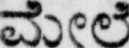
ಮೇಲೆ
